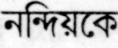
নন্দিয়কে
